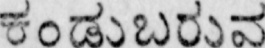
ಕಂಡುಬರುವ
